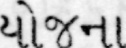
યોજના
